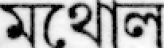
মথোল
